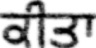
ਕੀਤਾ
